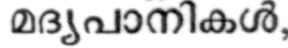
മദ്യപാനികള്‍,
